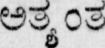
ಅತ್ಯಂತ
